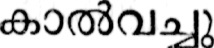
കാല്‍വച്ചു
